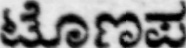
ಟೊಣಪ
